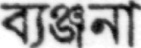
ব্যঞ্জনা
